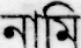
নামি
